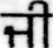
ਜੀ
